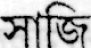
সাজি
